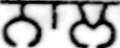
ਨਾਲ
